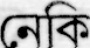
নেকি
